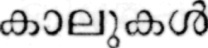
കാലുകള്‍
